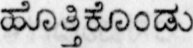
ಹೊತ್ತಿಕೊಂಡು
